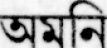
অমনি
